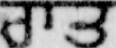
ਰਾਤ
